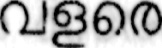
വളരെ
